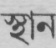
স্থান
